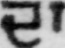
ਦਾ
